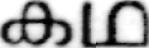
കഥ
